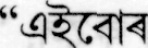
"এইবোৰ
